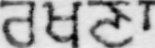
ਰਖਣਾ
